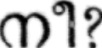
നീ?
